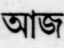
আজ
